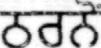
ਠਰਨੋਂ
